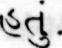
હતું.
